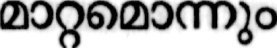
മാറ്റമൊന്നും
